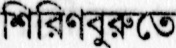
শিরিণবুরুতে
